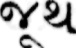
જૂથ
